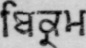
ਬਿਕ੍ਰਮ
